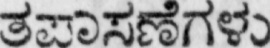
ತಪಾಸಣೆಗಳು
